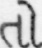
તો
